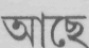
আছে
